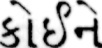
કોઈને
